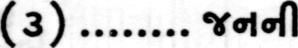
(૩).....જનની
